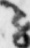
કે
